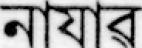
নাযাৱ
